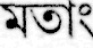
মতাং
